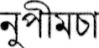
নুপীমচা
